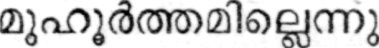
മുഹൂര്‍ത്തമില്ലെന്നു
